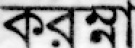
করম্না
